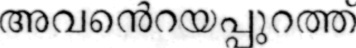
അവന്റെയപ്പുറത്ത്
